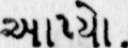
આપ્યો.ઊલટાનું
